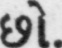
છો.
